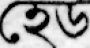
হেড
